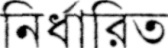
নির্ধারিত
